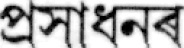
প্রসাধনৰ
